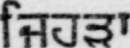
ਜਿਹੜਾ
